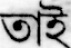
তাই
